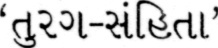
'તુરગ-સંહિતા'
